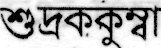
শুদ্রককুম্বা
